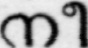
നീ
